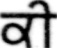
ਕੀ
